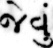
જેવું
